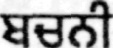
ਬਚਨੀ
